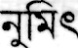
নুমিৎ
